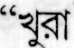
“খুরা
